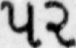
પર
